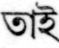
তাই
